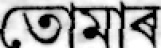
তোমাৰ
